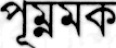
পূম্নমক
